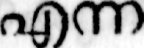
എന്ന
